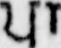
ਪਾ
